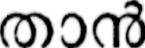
താന്‍
